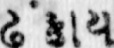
ઢંકાય
